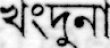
খংদুনা
